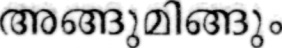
അങ്ങുമിങ്ങും
